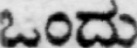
ಒಂದು
